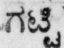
ಗಟ್ಟಿ
